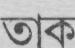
তাক
